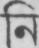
নি
